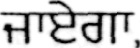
ਜਾਏਗਾ,
